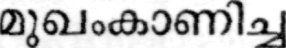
മുഖംകാണിച്ച
